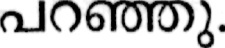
പറഞ്ഞു.
